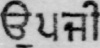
ਉਪਜੀ
